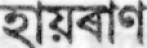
হায়ৰাণ
